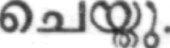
ചെയ്തു.
